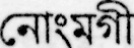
নোংমগী
